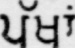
ਪੱਖਾਂ
